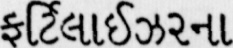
ફર્ટિલાઈજરના
